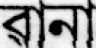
ৱানা
